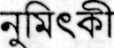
নুমিৎকী
